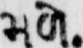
મળે.
